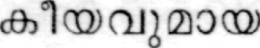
കീയവുമായ
